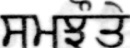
ਸਮਝੌਤੇ
